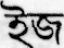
ইজ
